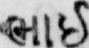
ભાઈ
